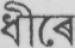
ধীৰে
